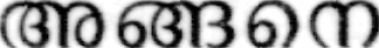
അങ്ങനെ
